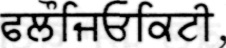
ਫਲੌਜਿਓਕਿਟੀ,
